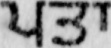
ਪਤਾ
